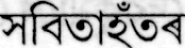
সবিতাহঁতৰ
